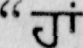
''ਹਾਂ
